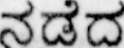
ನಡೆದ
